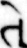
તે
